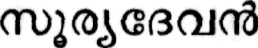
സൂര്യദേവന്‍
